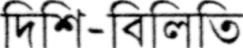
দিশি-বিলিতি
